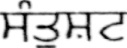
ਸੰਤੁਸ਼ਟ
